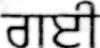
ਗਈ
